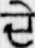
ਦੇ
